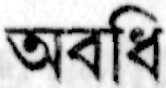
অবধি
